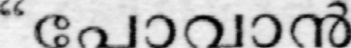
"പോവാന്‍
